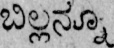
ಬಿಲ್ಲನ್ನೂ
